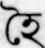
হৈ
